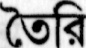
তৈরি
